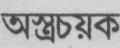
অস্ত্ৰচয়ক
